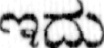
ಇದು
